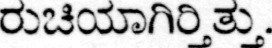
ರುಚಿಯಾಗಿರ್ತಿತ್ತು.
